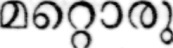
മറ്റൊരു
